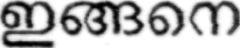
ഇങ്ങനെ
